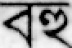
বছ
